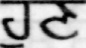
ਹੁਣ
